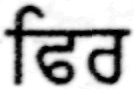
ਫਿਰ
